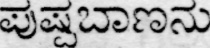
ಪುಷ್ಪಬಾಣನು
